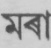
মৰা
